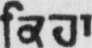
ਕਿਹਾ
